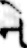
ને
